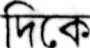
দিকে
